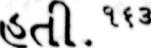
હતી.૧૬૩
